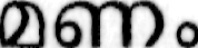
മണം
